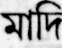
মাদি
